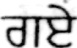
ਗਏ
